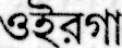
ওইরগা
